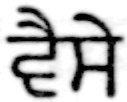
ਵੈਸੇ
